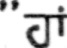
''ਹਾਂ
